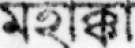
মহাক্কা
